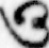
ও
